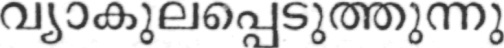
വ്യാകുലപ്പെടുത്തുന്നു
